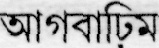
আগবাঢ়িম
